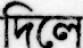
দিলে
